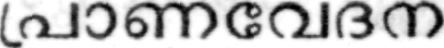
പ്രാണവേദന
